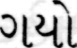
ગયો
